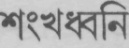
শংখধ্বনি
